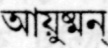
আয়ুষ্মন্
